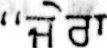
''ਜੇਰਾ
